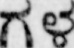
ಗಳ
